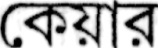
কেয়ার
